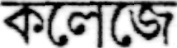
কলেজে
